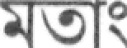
মতাং
